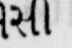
બેસી
